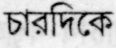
চারদিকে
